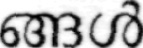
ങ്ങള്‍
